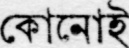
কোনোই
